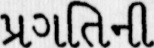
પ્રગતિની
